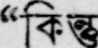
‘‘কিন্তু
